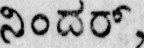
ನಿಂದರ್,
